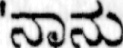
‘ನಾನು
